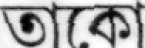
তাকো
